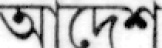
আদেশ
